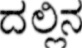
ದಲ್ಲಿನ
